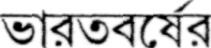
ভারতবর্ষের
